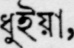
ধুইয়া,
